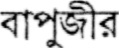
বাপুজীর
